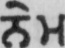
ਨੇਮ
